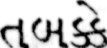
તબક્કે
